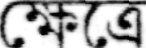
ক্ষেত্রে
